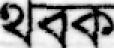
থবক
